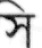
সি
